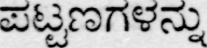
ಪಟ್ಟಣಗಳನ್ನು
